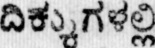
ದಿಕ್ಕುಗಳಲ್ಲಿ
